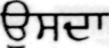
ਉਸਦਾ
